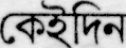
কেইদিন
